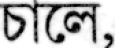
চালে,
